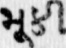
મૂકી
